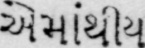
એમાંથીય
